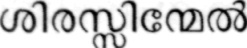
ശിരസ്സിന്മേല്‍
